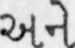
અને
